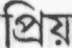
প্রিয়
